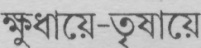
ক্ষুধায়ে-তৃষায়ে
